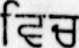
ਵਿਚ
